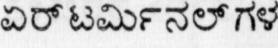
ಏರ್‌ಟರ್ಮಿನಲ್‌ಗಳ
